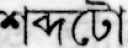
শব্দটো
